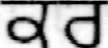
ਕਰ
